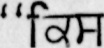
''ਕਿਸ
